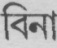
বিনা
